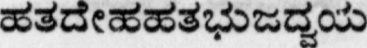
ಹತದೇಹಹತಭುಜದ್ವಯ
